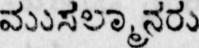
ಮುಸಲ್ಮಾನರು
